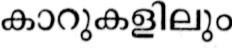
കാറുകളിലും
